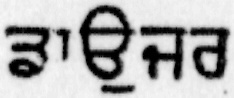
ਡਾਉਜਰ
